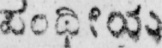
ಪಂಥೀಯ
